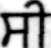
ਸੀ
